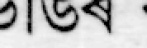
ডাঙৰ
